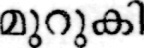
മുറുകി
